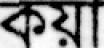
কয়া
